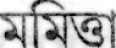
মমিত্তা
